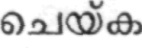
ചെയ്ക
